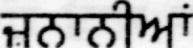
ਜ਼ਨਾਨੀਆਂ
